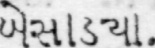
બેસાડ્યા.
